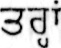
ਤਰ੍ਹਾਂ
